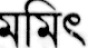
মমিৎ
